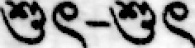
শুৎ-শুৎ
